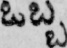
ಒಬ್ಬ
